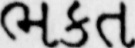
ભક્ત
